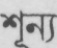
শূন্য
